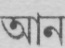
আন
